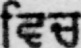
ਵਿਚ
